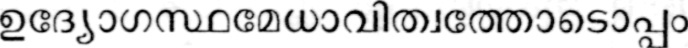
ഉദ്യോഗസ്ഥമേധാവിത്വത്തോടൊപ്പം
